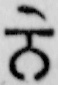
ਨੇ
